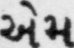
એમ
